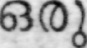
ഒരു
